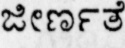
ಜೀರ್ಣತೆ
